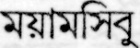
ময়ামসিবু
